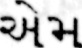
એમ
